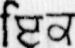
ਇਕ
